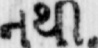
નથી.
